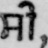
ਸੀ,
